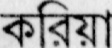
করিয়া
